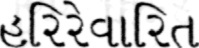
હરિરેવારિત
